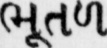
ભૂતળ
